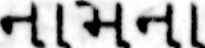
નામના
